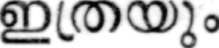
ഇത്രയും
